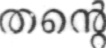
തന്റെ
